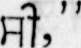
ਸੀ,''
